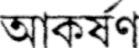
আকর্ষণ
